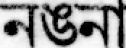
নঙনা
